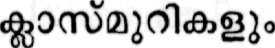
ക്ലാസ്മുറികളും
